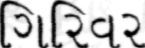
ગિરિવર
